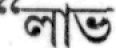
"লাভ
